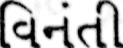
વિનંતી
